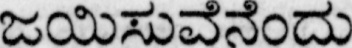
ಜಯಿಸುವೆನೆಂದು
